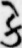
કે
